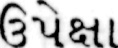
ઉપેક્ષા
